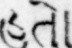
હતો
